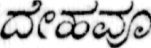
ದೇಹವೂ
